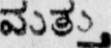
ಮತ್ತು
